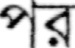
পর
